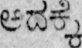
ಅದಕ್ಕೆ
